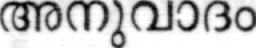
അനുവാദം
